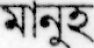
মানুহ
